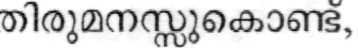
തിരുമനസ്സുകൊണ്ട്,
